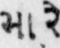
મારે
